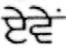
ਏਵੇਂ
